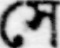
সে
